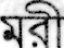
মরী
